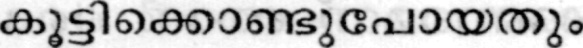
കൂട്ടിക്കൊണ്ടുപോയതും
